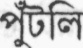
পুঁটলি
